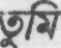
তুমি
